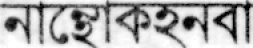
নান্থোকহনবা
